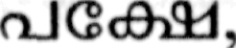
പക്ഷേ,
